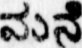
ಮನೆ
